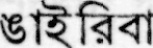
ঙাইরিবা
